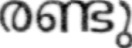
രണ്ടു
